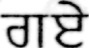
ਗਏ
